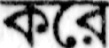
করে
